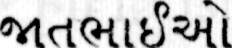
જાતભાઈઓ
